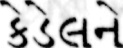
કેડેલને
